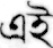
এই
